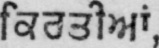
ਕਿਰਤੀਆਂ,
